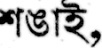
শঙাই,
